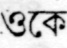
ওকে
